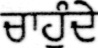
ਚਾਹੁੰਦੇ
